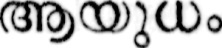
ആയുധം
